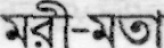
মরী-মতা
